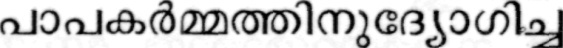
പാപകര്‍മ്മത്തിനുദ്യോഗിച്ച
